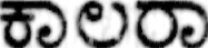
ಕಾಲರಾ
